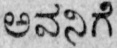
ಅವನಿಗೆ
